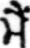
ਮੈਂ
